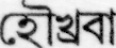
হৌখ্রবা
